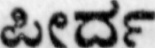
ಪೀರ್ದ
